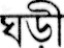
ঘড়ী
